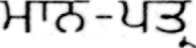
ਮਾਨ-ਪਤ੍ਰ
